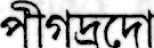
পীগদ্রদো
